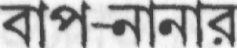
বাপ-নানার
